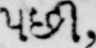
પછી,
